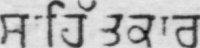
ਸਹਿੱਤਕਾਰ
